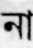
না
